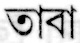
তাবা
